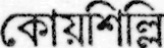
কোয়শিল্লি
